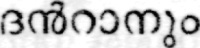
ദന്റാനും
